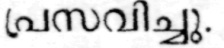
പ്രസവിച്ചു.
